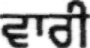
ਵਾਰੀ
